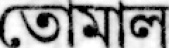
তোমাল
